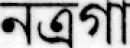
নত্রগা
